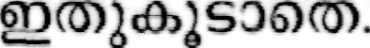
ഇതുകൂടാതെ.
